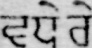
ਵਧੇਰੇ
